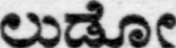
ಲುಡೋ
